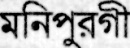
মনিপুরগী
